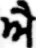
ਐ
